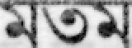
মতম
